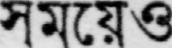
সময়েও
